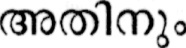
അതിനും
